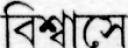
বিশ্বাসে
